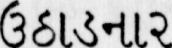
ઉઠાડનાર
